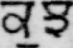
ਕੁਝ
